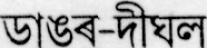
ডাঙৰ-দীঘল
